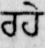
ਰਹੇ
